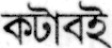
কটাবই
